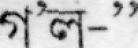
গ'ল-"
